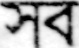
সব
